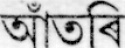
আঁতৰি
